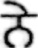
ਨੇ
